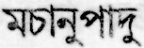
মচানুপাদু
